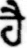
ਹੈ
